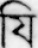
যি
